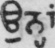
ਉਨ੍ਹਾਂ
